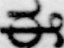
ಈ
